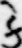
કે
